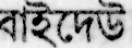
বাইদেউ
